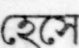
হেসে
